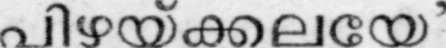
പിഴയ്ക്കലയേ’
